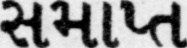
સમાપ્ત
